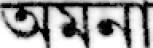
অমনা
